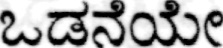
ಒಡನೆಯೇ
